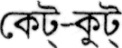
কেট্‌-কুট্
